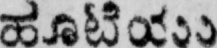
ಹೂಟೆಯು
